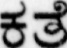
ಕತೆ
